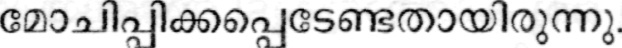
മോചിപ്പിക്കപ്പെടേണ്ടതായിരുന്നു.
